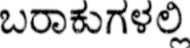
ಬರಾಕುಗಳಲ್ಲಿ
